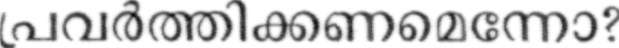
പ്രവര്‍ത്തിക്കണമെന്നോ?
